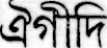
ঐগীদি
